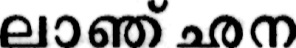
ലാഞ്ഛന
